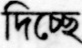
দিচ্ছে
